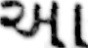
આ
